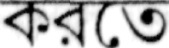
করতে
